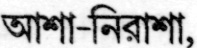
আশা-নিরাশা,
